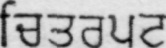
ਚਿਤਰਪਟ
